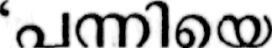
‘പന്നിയെ
